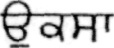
ਉਕਸਾ
